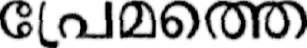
പ്രേമത്തെ
